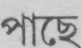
পাছে
